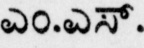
ಎಂ.ಎಸ್.
